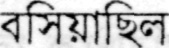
বসিয়াছিল
